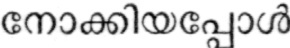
നോക്കിയപ്പോള്‍
